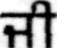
ਜੀ
